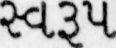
સ્વરૂપ
